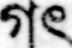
গৎ
